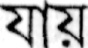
যায়
